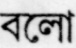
বলো
